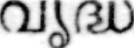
വൃദ്ധ
